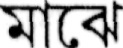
মাঝে
